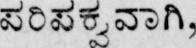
ಪರಿಪಕ್ವವಾಗಿ,
